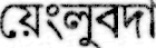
য়েংলুবদা
